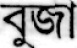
বুজা
